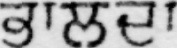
ਭਾਲਦਾ
